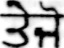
ਤੇਜੋ
